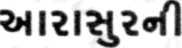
આરાસૂરની
